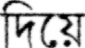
দিয়ে
